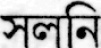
সলনি
